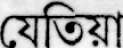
যেতিয়া
